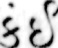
કંઈ
